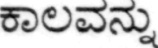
ಕಾಲವನ್ನು
